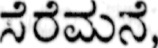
ಸೆರೆಮನೆ,
